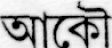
আকৌ
